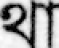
থা
